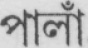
পালাঁ
